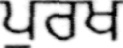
ਪੁਰਖ
